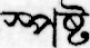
স্পষ্ট
